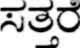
ಸತ್ತರೆ
